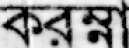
করম্না
